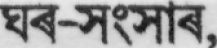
ঘৰ-সংসাৰ,
